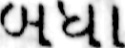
બધા
